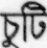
চুটি
